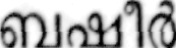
ബഷീര്‍
